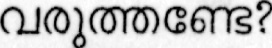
വരുത്തണ്ടേ?
